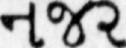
નજર
